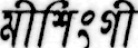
মীশিংগী
